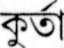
কুর্তা
